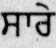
ਸਾਰੇ
